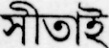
সীতাই
